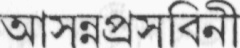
আসন্নপ্রসবিনী
